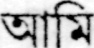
আমি
